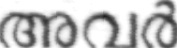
അവര്‍
